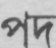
পদ
